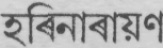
হৰিনাৰায়ণ
